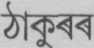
ঠাকুৰৰ
